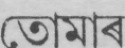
তোমাৰ
